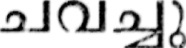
ചവച്ചു
